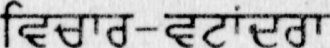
ਵਿਚਾਰ-ਵਟਾਂਦਰਾ
